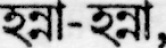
হন্না-হন্না,
